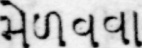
મેળવવા
